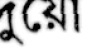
দুয়ো
